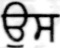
ਉਸ
